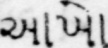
આખો
